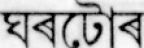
ঘৰটোৰ
